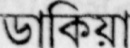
ডাকিয়া
